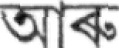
আৰু
